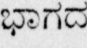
ಭಾಗದ
